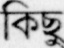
কিছু
